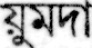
য়ুমদা
